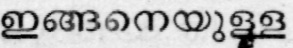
ഇങ്ങനെയുള്ള
